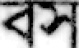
বস
